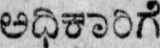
ಅಧಿಕಾರಿಗೆ
